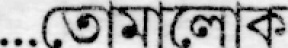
...তোমালোক
